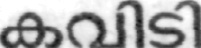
കവിടി
